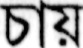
চায়
